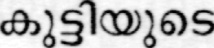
കുട്ടിയുടെ
